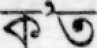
ক'ত
